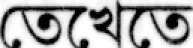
তেখেতে
